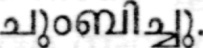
ചുംബിച്ചു.
